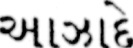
આઝાદે
